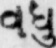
વધુ
